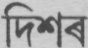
দিশৰ
